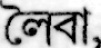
লৈবা,
